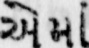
એમાં
